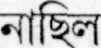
নাছিল
